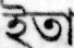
ইতা
